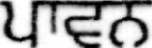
ਪਾਵਨ
